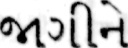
જાગીને
